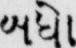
બધો
